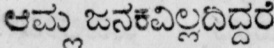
ಆಮ್ಲಜನಕವಿಲ್ಲದಿದ್ದರೆ
